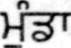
ਮੁੰਡਾ
